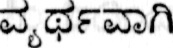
ವ್ಯರ್ಥವಾಗಿ
